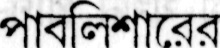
পাবলিশারের
